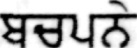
ਬਚਪਨੇ
